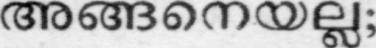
അങ്ങനെയല്ല;
